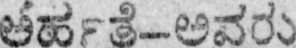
ಅರ್ಹತೆ-ಅವರು
